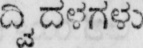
ದ್ವಿದಳಗಳು
